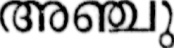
അഞ്ചു
